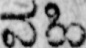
ವಹಿ
